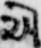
એ
